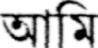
আমি
